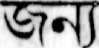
জন্য
